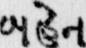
બહેન
